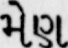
મેણ
